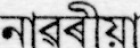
নাৱৰীয়া
